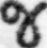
જ
